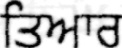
ਤਿਆਰ
